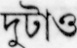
দুটাও
